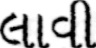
લાવી
